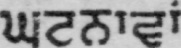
ਘਟਨਾਵਾਂ
